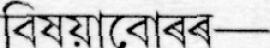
বিষয়াবোৰৰ-
